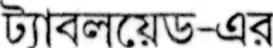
ট্যাবলয়েড-এর
